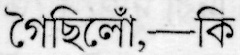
গৈছিলোঁ,-কি
